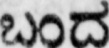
ಬಂದ
